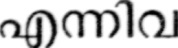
എന്നിവ
